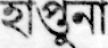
হাপ্তুনা
